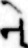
ને
